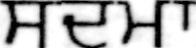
ਸਦਮਾ
